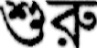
শুরু
